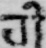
ਹੀ
